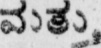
ಮತ್ತು
